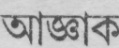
আজ্ঞাক
